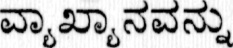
ವ್ಯಾಖ್ಯಾನವನ್ನು
